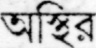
অস্থির
